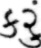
કરું
